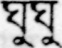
ঘুঘু
